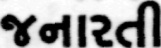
જનારતી
